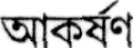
আকর্ষণ
